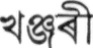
খঞ্জৰী
